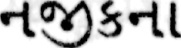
નજીકના
